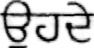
ਉਹਦੇ
